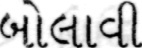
બોલાવી
